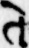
તે
